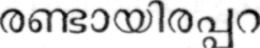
രണ്ടായിരപ്പറ
